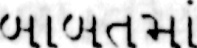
બાબતમાં
